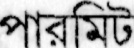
পারমিট
